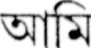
আমি
